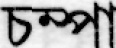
চম্পা
